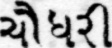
ચૌધરી
